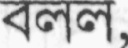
বলল,
